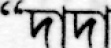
“দাদা
